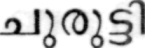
ചുരുട്ടി
